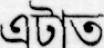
এটাত
